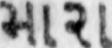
મારા
